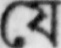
যে
